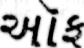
ઑફ
